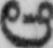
ಆ
